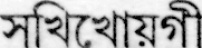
সখিখোয়গী
